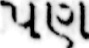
પણ
